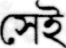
সেই
